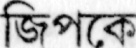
জিপকে
